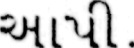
આપી.
